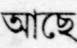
আছে
